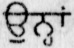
ਉਨ੍ਹਾਂ
